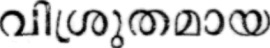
വിശ്രുതമായ
